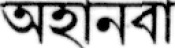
অহানবা
